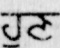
ਹੁਣ
